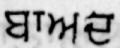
ਬਾਅਦ
